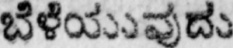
ಬೆಳೆಯುವುದು
